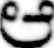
ಆ
